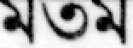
মতম
